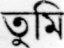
তুমি
